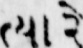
ત્યારે
